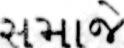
સમાજે
